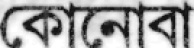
কোনোবা
